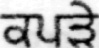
ਕਪੜੇ
